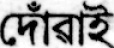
দোঁৱাই
